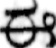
ಈ
